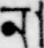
না
